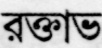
রক্তাভ
